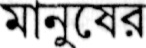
মানুষের
